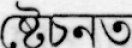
ষ্টেচনত
